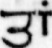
ਤਾਂ
